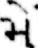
મેં
